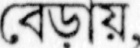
বেড়ায়,
